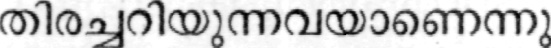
തിരച്ചറിയുന്നവയാണെന്നു
